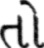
તો
